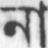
না
